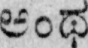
ಅಂಥ
